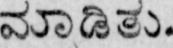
ಮಾಡಿತು.
